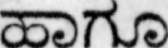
ಹಾಗೂ
